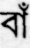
বাঁ
